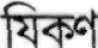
যিকণ
